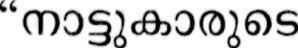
"നാട്ടുകാരുടെ
